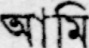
আমি
